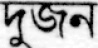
দুজন
